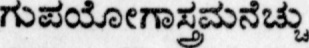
ಗುಪಯೋಗಾಸ್ತ್ರಮನೆಚ್ಚು
